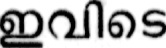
ഇവിടെ
